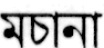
মচানা
